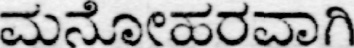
ಮನೋಹರವಾಗಿ
